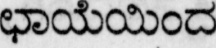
ಛಾಯೆಯಿಂದ
